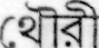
থৌরী
